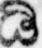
ಡಿ
